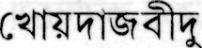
খোয়দাজবীদু
